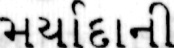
મર્યાદાની
